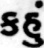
કહું
